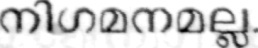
നിഗമനമല്ല.
